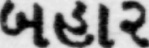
બહાર
